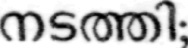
നടത്തി;
